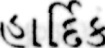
હાર્દિક
